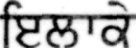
ਇਲਾਕੇ
